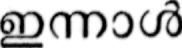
ഇന്നാള്‍
